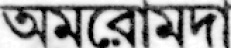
অমরোমদা
